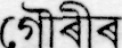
গৌৰীৰ
